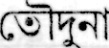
তৌদুনা
